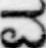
ವ
